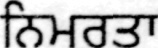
ਨਿਮਰਤਾ
